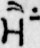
ਮੈਂ
